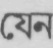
যেন
